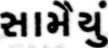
સામૈયું
